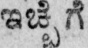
ಇಚ್ಛೆಗೆ
